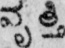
ವೃತ್ತಿ
